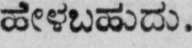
ಹೇಳಬಹುದು.
